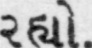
રહ્યો.
